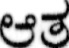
ಆತ
